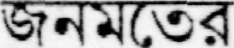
জনমতের
